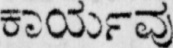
ಕಾರ್ಯವು
